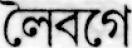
লৈবগে
